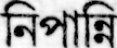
নিপান্নি
